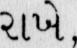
રાખે,
